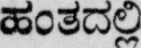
ಹಂತದಲ್ಲಿ
